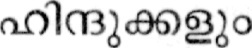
ഹിന്ദുക്കളും
